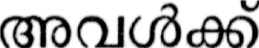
അവള്‍ക്ക്
